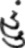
હું
